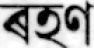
ৰহণ
